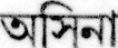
অসিনা
